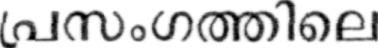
പ്രസംഗത്തിലെ
